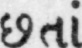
છતાં
